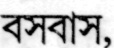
বসবাস,
